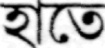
হাতে
